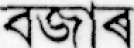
বজাৰ
